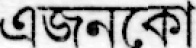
এজনকো
